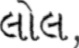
લોલ,
